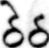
ઠેઠ
